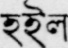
হইল
